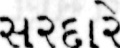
સરદારે
